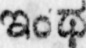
ಇಂಥ
